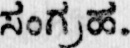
ಸಂಗ್ರಹ.
